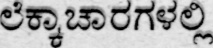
ಲೆಕ್ಕಾಚಾರಗಳಲ್ಲಿ
